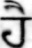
ਹੈ
